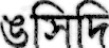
ঙসিদি
